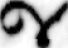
જ
